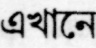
এখানে
